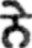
ਨੇ
